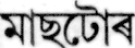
মাছটোৰ
